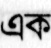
এক
